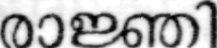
രാജ്ഞി
